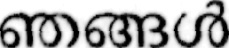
ഞങ്ങള്‍
